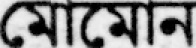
মোমোন
